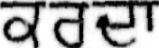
ਕਰਦਾ
